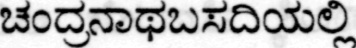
ಚಂದ್ರನಾಥಬಸದಿಯಲ್ಲಿ
